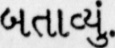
બતાવ્યું.
